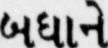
બધાને
